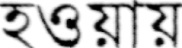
হওয়ায়
